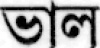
ভাল
